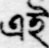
এই
